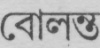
বোলন্ত
